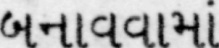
બનાવવામાં
